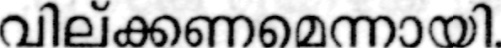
വില്ക്കണമെന്നായി.
